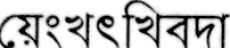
য়েংখৎখিবদা
